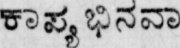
ಕಾಪ್ಯಭಿನವಾ
